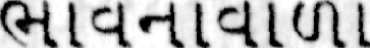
ભાવનાવાળા
